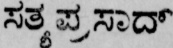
ಸತ್ಯಪ್ರಸಾದ್
